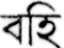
বহি
